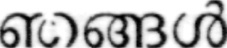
ഞങ്ങള്‍
